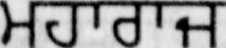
ਮਹਾਰਾਜ
